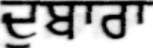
ਦੁਬਾਰਾ
